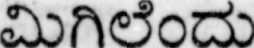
ಮಿಗಿಲೆಂದು
